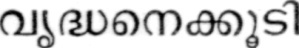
വൃദ്ധനെക്കൂടി
